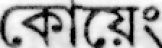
কোয়েং
